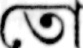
তো
